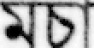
মচা
